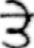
ਤੇ
